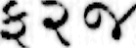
ફરજ
